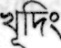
খূদিং
